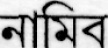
নামিব
